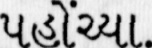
પહોંચ્યા.
